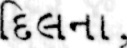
દિલના,
